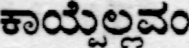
ಕಾಯ್ಪೆಲ್ಲವಂ
